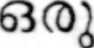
ഒരു
